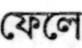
ফেলে
